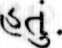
હતું.
